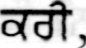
ਕਰੀ,
